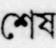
শেষ
